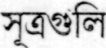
সূত্রগুলি
